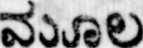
ಮೂಲ
